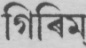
গিৰিম্
